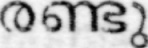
രണ്ടു
